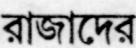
রাজাদের
